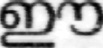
ഈ
